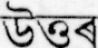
উত্তৰ
